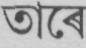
তাৰে
